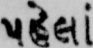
પહેલાં
